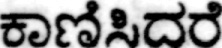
ಕಾಣಿಸಿದರೆ
